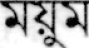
ময়ুম
